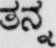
ತನ್ನ
